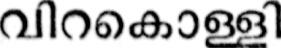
വിറകൊള്ളി
